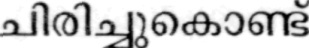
ചിരിച്ചുകൊണ്ട്
